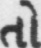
તો
